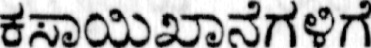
ಕಸಾಯಿಖಾನೆಗಳಿಗೆ
